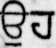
ਉਹ
